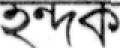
হন্দক
